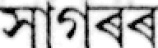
সাগৰৰ
